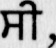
ਸੀ,
